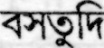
বসতুদি
